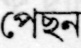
পেছন
